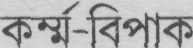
কৰ্ম্ম-বিপাক
